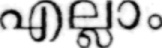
എല്ലാം
